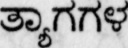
ತ್ಯಾಗಗಳ
